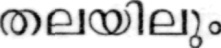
തലയിലും
